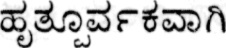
ಹೃತ್ಪೂರ್ವಕವಾಗಿ
